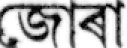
জোৰা
